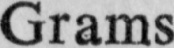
Grams
